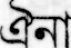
ঐনা
